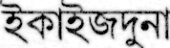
ইকাইজদুনা
